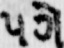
પગે
